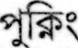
পুক্নিং
